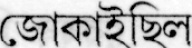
জোকাইছিল
